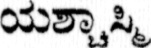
ಯಶ್ಚಾಸ್ಮಿ
